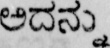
ಅದನ್ನು
